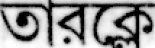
তারক্লে
